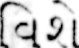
વિશે
